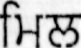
ਮਿਲ
